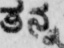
ತನ್ನ
